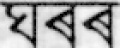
ঘৰৰ
